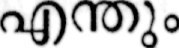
എന്തും
